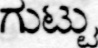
ಗುಟ್ಟು
